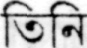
তিনি
